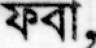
ফবা,
